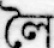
লৈ
